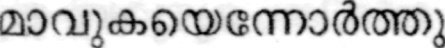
മാവുകയെന്നോര്‍ത്തു
